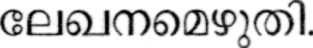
ലേഖനമെഴുതി.
